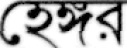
হেঙ্গর
